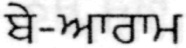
ਬੇ-ਆਰਾਮ
